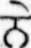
ਨੇ
